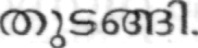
തുടങ്ങി.
